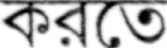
করতে
